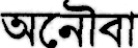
অনৌবা
